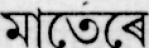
মাতেৰে
